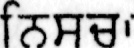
ਨਿਸਚਾ
